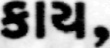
કાય,
